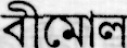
বীমোল
